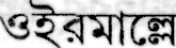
ওইরমাল্লে
